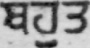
ਬਹੁਤ
